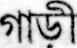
গাড়ী
